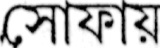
সোফায়
